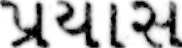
પ્રયાસ
